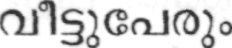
വീട്ടുപേരും
